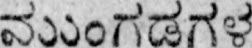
ಮುಂಗಡಗಳ
